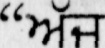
''ਅੱਜ
